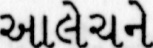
આલેચને
